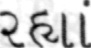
રહ્યાં
